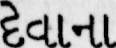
દેવાના
